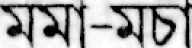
মমা-মচা
